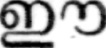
ഈ
